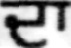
ਦਾ
